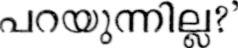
പറയുന്നില്ല?’
